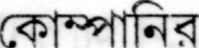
কোম্পানির
